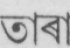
তাৰা
